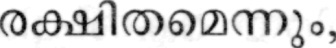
രക്ഷിതമെന്നും,
